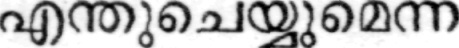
എന്തുചെയ്യുമെന്ന
